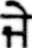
ਜੇ
